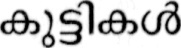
കുട്ടികള്‍
